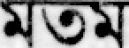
মতম
